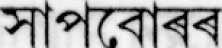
সাপবোৰৰ
